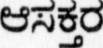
ಆಸಕ್ತರ
